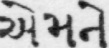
એમને
